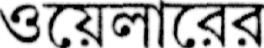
ওয়েলারের
